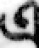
এ
